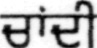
ਚਾਂਦੀ
